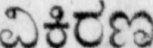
ವಿಕಿರಣ
